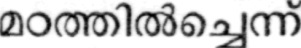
മഠത്തില്‍ച്ചെന്ന്
